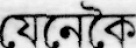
যেনেকৈ
